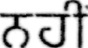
ਨਹੀਂ
